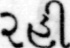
રહી
